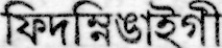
ফিদম্নিঙাইগী
